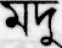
মদু
